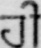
ਹੀ
